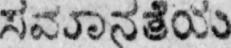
ಸಮಾನತೆಯ
